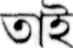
তাই
